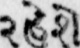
રહેશે
